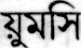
য়ুমসি
